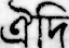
ঐদি
